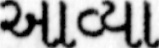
આવ્યા
